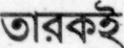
তারকই
